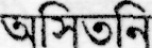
অসিতনি
